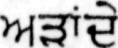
ਅੜਾਂਦੇ
